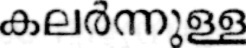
കലര്‍ന്നുള്ള
